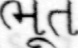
ભૂત
